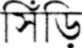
সিঁড়ি
